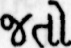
જતો
